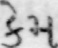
કેમ
